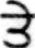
ਤੇ
